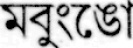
মবুংঙো
